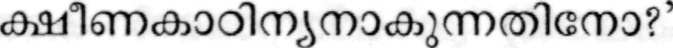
ക്ഷീണകാഠിന്യനാകുന്നതിനോ?'
